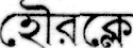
হৌরক্লে
